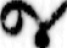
જ
